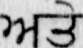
ਅਤੇ
